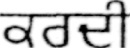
ਕਰਦੀ
